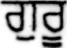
ਗੁਰੂ
